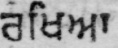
ਰਖਿਆ
